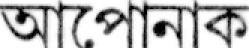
আপোনাক
